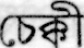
চেক্কী
